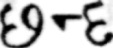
છન્દ
